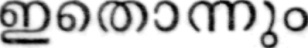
ഇതൊന്നും
